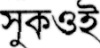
সুকওই
